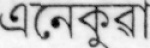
এনেকুৱা
